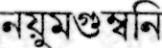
নয়ুমগুম্বনি
